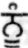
ਨੂੰ
